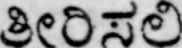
ತೀರಿಸಲಿ
